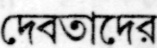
দেবতাদের
